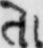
તો
